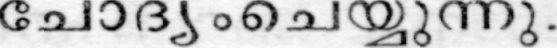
ചോദ്യംചെയ്യുന്നു.
